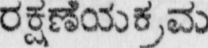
ರಕ್ಷಣೆಯಕ್ರಮ
